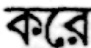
করে
